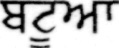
ਬਟੂਆ
